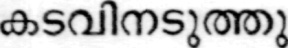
കടവിനടുത്തു
